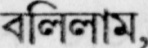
বলিলাম,
